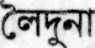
লৈদুনা
